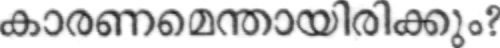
കാരണമെന്തായിരിക്കും?
